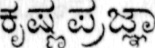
ಕೃಷ್ಣಪ್ರಜ್ಞಾ
